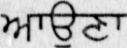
ਆਉਣਾ
